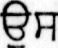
ਉਸ
